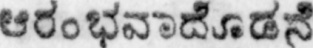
ಆರಂಭವಾದೊಡನೆ
